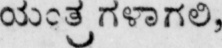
ಯಂತ್ರಗಳಾಗಲಿ,
